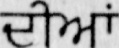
ਦੀਆਂ
